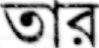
তার
